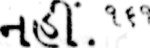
નહીં.૧૬૧
